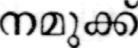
നമുക്ക്
